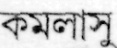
কমলাসু
